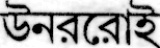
উনররোই
